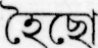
হৈছো
